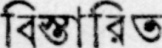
বিস্তারিত
